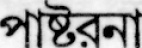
পাষ্টরনা
